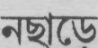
নছাড়ে
